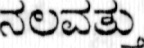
ನಲವತ್ತು
